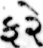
ફરે
